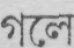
গলে
